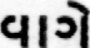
વાગે
